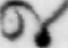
જ
